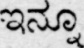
ಇನ್ನೂ
